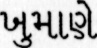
ખુમાણે
